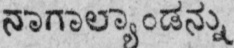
ನಾಗಾಲ್ಯಾಂಡನ್ನು
